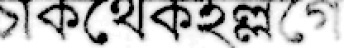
চাকথেকহল্লগে
